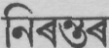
নিৰন্তৰ
